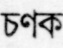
চণক
